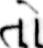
તો
